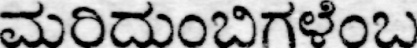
ಮರಿದುಂಬಿಗಳೆಂಬ
